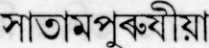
সাতামপুৰুযীয়া
